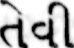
તેવી
